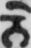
ਨੇ
